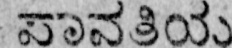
ಪಾವತಿಯ
